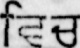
ਵਿਚ
